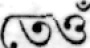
তেওঁ
